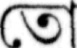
তো
